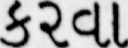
કરવા
